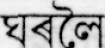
ঘৰলৈ
